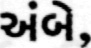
અંખે,
